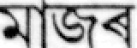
মাজৰ
